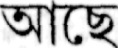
আছে
